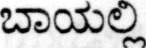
ಬಾಯಲ್ಲಿ
